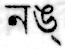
নঙ্
